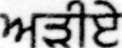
ਅੜੀਏ
